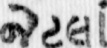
જેટલાં
